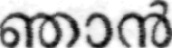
ഞാന്‍
